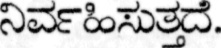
ನಿರ್ವಹಿಸುತ್ತದೆ.
